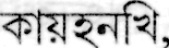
কায়হনখি,
